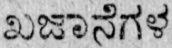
ಖಜಾನೆಗಳ
